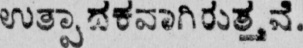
ಉತ್ಪಾದಕವಾಗಿರುತ್ತವೆ.
